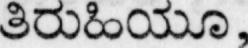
ತಿರುಹಿಯೂ,
